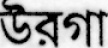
উরগা
